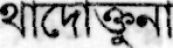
থাদোক্তুনা
